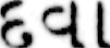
દવા
